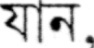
যান,
